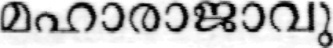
മഹാരാജാവു
